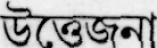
উত্তেজনা
